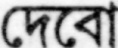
দেবো
